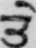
ਤੇ
